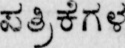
ಪತ್ರಿಕೆಗಳ
